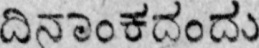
ದಿನಾಂಕದಂದು
